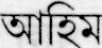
আহিম
